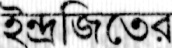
ইন্দ্রজিতের
